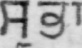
ਸੁਭਾ
